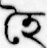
হৈ
